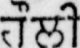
ਹੌਲੀ
